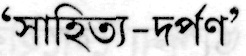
‘সহিত্য-দর্শণ’
